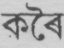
কৰৈ
